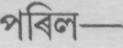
পৰিল-
